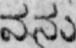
ವನು
